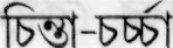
চিন্তা-চৰ্চ্চা
